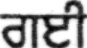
ਗਈ
